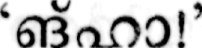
‘ങ്ഹാ!’
